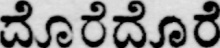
ದೊರೆದೊರೆ
